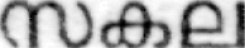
സകല
